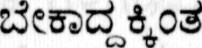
ಬೇಕಾದ್ದಕ್ಕಿಂತ
